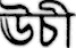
ঊচী
